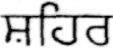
ਸ਼ਹਿਰ
